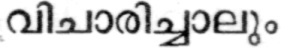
വിചാരിച്ചാലും
